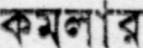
কমলার
